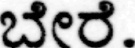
ಬೇರೆ.
